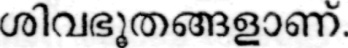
ശിവഭൂതങ്ങളാണ്.
